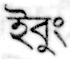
ইবুং
